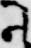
ને
